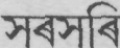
সৰসৰি
